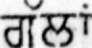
ਗੱਲਾਂ
